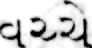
વચ્ચે
